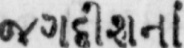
જગદીશનાં
